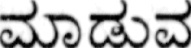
ಮಾಡುವ
